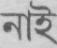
নাই
